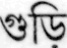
গুড়ি
